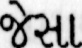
જેસા
